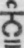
ਨੂੰ
